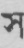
স
